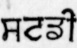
ਸਟਡੀ
